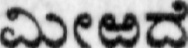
ಮೀಱದೆ
